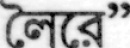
লৈরে”
